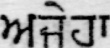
ਅਜੇਹਾ
